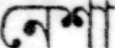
নেশা
